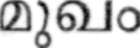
മുഖം
